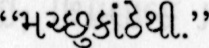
"મચ્છુકાંઠેથી."
